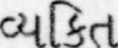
વ્યક્તિ
